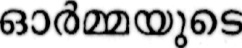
ഓര്‍മ്മയുടെ
